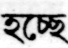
হচ্ছে
